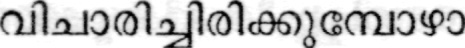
വിചാരിച്ചിരിക്കുമ്പോഴാ
